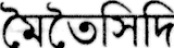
মৈতৈসিদি
